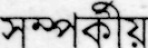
সম্পৰ্কীয়
